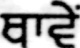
ਥਾਵੇਂ
